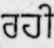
ਰਹੀ
